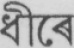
ধীৰে
